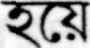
হয়ে
